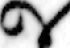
જ
